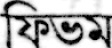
ফিভম
